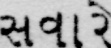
સવારે
